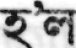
হ'ল
